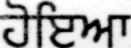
ਹੋਇਆ
